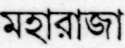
মহারাজা
